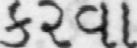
કરવા
